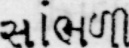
સાંભળી
